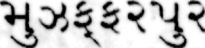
મુઝફ્ફરપુર
